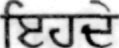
ਇਹਦੇ
